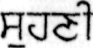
ਸੁਹਣੀ
